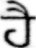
ਹੈ
